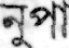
নুপা
